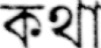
কথা
